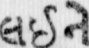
લઈને
